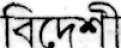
বিদেশী
